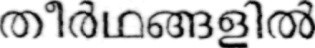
തീര്‍ഥങ്ങളില്‍
